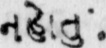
નહોતું.
